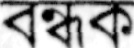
বন্ধক
